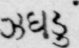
ઝઘડું
